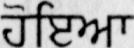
ਹੋਇਆ
